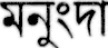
মনুংদা
